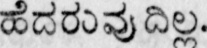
ಹೆದರುವುದಿಲ್ಲ.
